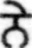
ਨੇ
